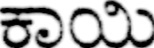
ಕಾಯಿ
